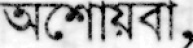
অশোয়বা,
